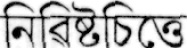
নিৱিষ্টচিত্তে
